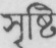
সৃষ্টি
